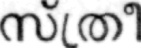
സ്ത്രീ
